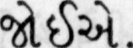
જોઈએ.
